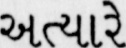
અત્યારે
